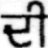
ਦੀ
